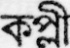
কপ্লী
